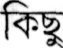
কিছু
